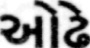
ઓઢે
